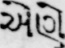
એણે
